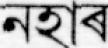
নহাৰ
